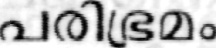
പരിഭ്രമം
